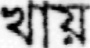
খায়
